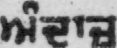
ਅੰਦਾਜ਼
